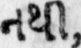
નથી,
